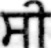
ਸੀ
